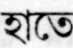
হাতে
